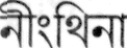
নীংথিনা
